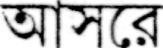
আসরে
